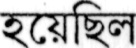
হয়েছিল
